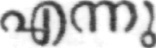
എന്നു
